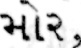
મોર,
